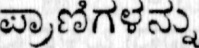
ಪ್ರಾಣಿಗಳನ್ನು
